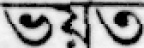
ভয়ত
